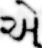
એ
